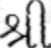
શ્રી
